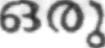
ഒരു
